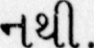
નથી.
